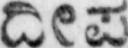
ದೀಪ
